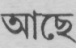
আছে
